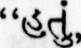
"હતું,
